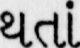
થતાં
